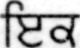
ਇਕ
